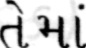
તેમાં
